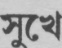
সুখে
